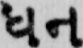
ધન
